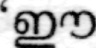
‘ഈ
